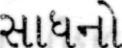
સાધનો
